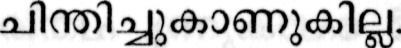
ചിന്തിച്ചുകാണുകില്ല.
